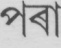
পৰা
